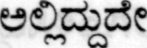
ಅಲ್ಲಿದ್ದುದೇ
